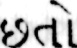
છતો
